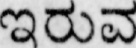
ಇರುವ
